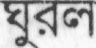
ঘুরল
